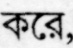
করে,
